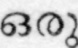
ഒരു
